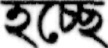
হচ্ছে
